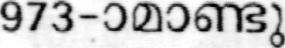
973-ാമാണ്ടു
